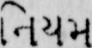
નિયમ
